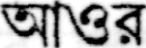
আওর
